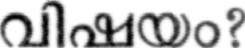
വിഷയം?
